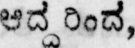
ಆದ್ದರಿಂದ,
